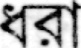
ধরা
